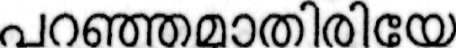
പറഞ്ഞമാതിരിയേ
